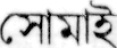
সোমাই
